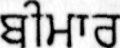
ਬੀਮਾਰ
